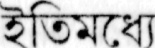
ইতিমধ্যে
